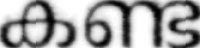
കണ്ട
